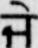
ਜੇ
